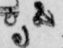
ಕೃಷಿ
